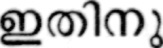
ഇതിനു
